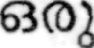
ഒരു
